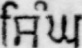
ਸਿੰਘ
